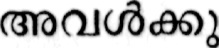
അവള്‍ക്കു
